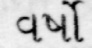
વર્ષો
